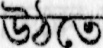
উঠতে
